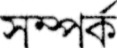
সম্পর্ক
